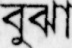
বুঝা
